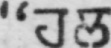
''ਹਲ
